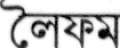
লৈফম
